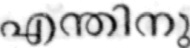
എന്തിനു
